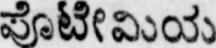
ಪೊಟೇಮಿಯ
